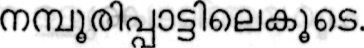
നമ്പൂരിപ്പാട്ടിലെകൂടെ.
